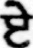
ਏ
